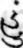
હું
